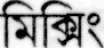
মিক্সিং
